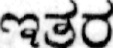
ಇತರ
